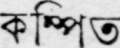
কম্পিত
